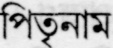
পিতৃনাম
